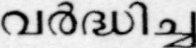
വര്‍ദ്ധിച്ച
